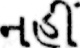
નહીં
